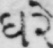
ઘરે
